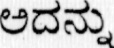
ಅದನ್ನು
